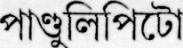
পাণ্ডুলিপিটো
